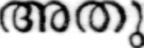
അതു
